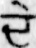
ਦੇ
